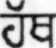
ਹੱਥ
